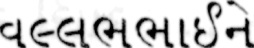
વલ્લભભાઈને
